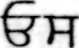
ਓਸ
